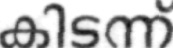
കിടന്ന്
